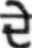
ਦੇ
